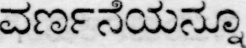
ವರ್ಣನೆಯನ್ನೂ
